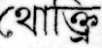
থোক্ত্রি
